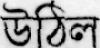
উঠিল
